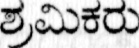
ಶ್ರಮಿಕರು
